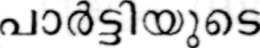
പാര്‍ട്ടിയുടെ
